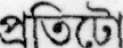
প্রতিটো
